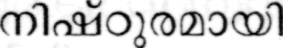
നിഷ്ഠുരമായി
